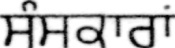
ਸੰਸਕਾਰਾਂ
